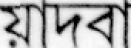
য়াদবা
